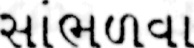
સાંભળવા
